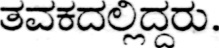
ತವಕದಲ್ಲಿದ್ದರು.
